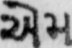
એમ
